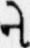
ને
